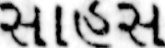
સાહસ
